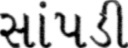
સાંપડી
